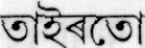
তাইৰতো
